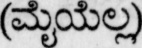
(ಮೈಯೆಲ್ಲ)
